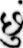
છું
